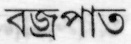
বজ্ৰপাত
